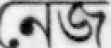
নেজ
